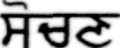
ਸੋਚਣ
